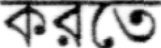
করতে
